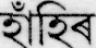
হাঁহিৰ
